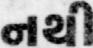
નથી
